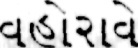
વહોરાવે
